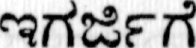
ಇಗರ್ಜಿಗೆ
